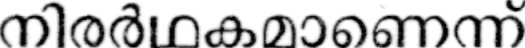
നിരര്‍ഥകമാണെന്ന്
